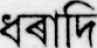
ধৰাদি
